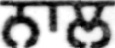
ਨਾਲ
